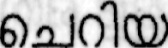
ചെറിയ
